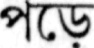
পড়ে
